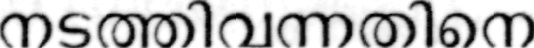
നടത്തിവന്നതിനെ
